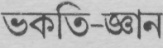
ভকতি-জ্ঞান
